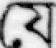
যে
